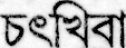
চৎখিবা
